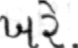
ખરે.
